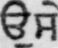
ਉਸੇ
